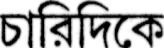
চারিদিকে
